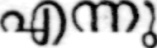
എന്നു
